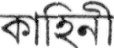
কাহিনী
